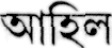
আহিল
